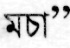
মচা”
